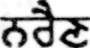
ਨਰੈਣ
